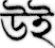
উই
